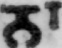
ਨਾ
